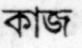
কাজ
